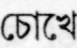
চোখে
